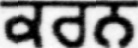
ਕਰਨ
